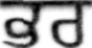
ਭਰ
